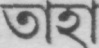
তাহা
